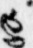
હું
